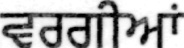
ਵਰਗੀਆਂ
